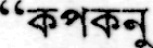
“কপকনু
